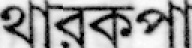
থারকপা
